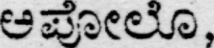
ಅಪೋಲೊ,
